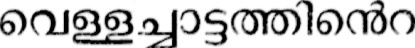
വെള്ളച്ചാട്ടത്തിന്റെ
